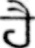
ਹੈ
